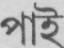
পাই
